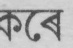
কৰে
